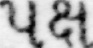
પક્ષ
